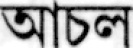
আচল
